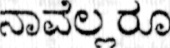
ನಾವೆಲ್ಲರೂ
